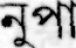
নুপা
